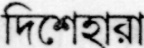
দিশেহারা
